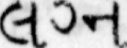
લગ્ન
